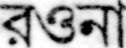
রওনা
